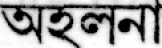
অহলনা
